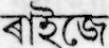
ৰাইজে
